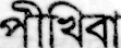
পীখিবা
